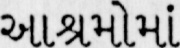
આશ્રમોમાં
